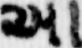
આ
